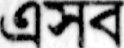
এসব
